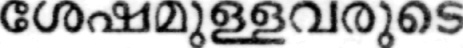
ശേഷമുള്ളവരുടെ
